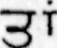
ਤਾਂ
